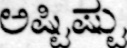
ಅಷ್ಟಿಷ್ಟು
